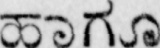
ಹಾಗೂ
